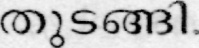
തുടങ്ങി.
